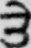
ਤੇ
